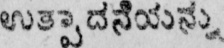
ಉತ್ಪಾದನೆಯನ್ನು
